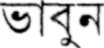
ভাবুন
